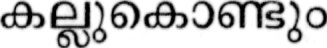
കല്ലുകൊണ്ടും
